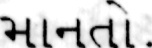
માનતો.
